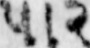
પાર
